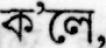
ক'লে,
